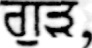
ਗੁੜ,
